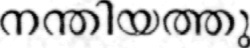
നന്തിയത്തു
